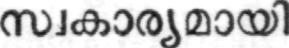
സ്വകാര്യമായി
